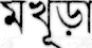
মখুড়া
